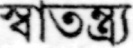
স্বাতন্ত্র্য
